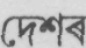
দেশৰ
